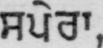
ਸਪੇਰਾ,
